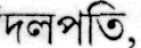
'দলপতি,
